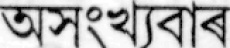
অসংখ্যবাৰ
